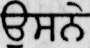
ਉਸਨੇ
